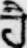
ਹੈ
